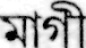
মাগী
